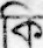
কি
